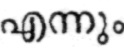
എന്നും
